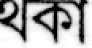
থকা
